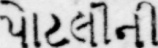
પોટલીની
